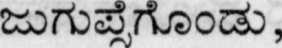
ಜುಗುಪ್ಸೆಗೊಂಡು,
